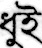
ধুই
